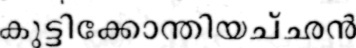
കുട്ടിക്കോന്തിയച്ഛന്‍
